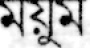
ময়ুম
